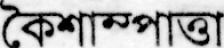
কৈশাম্পাত্তা
